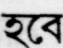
হবে
